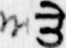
ਅਤੇ
